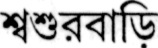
শ্বশুরবাড়ি
